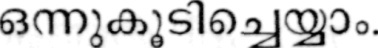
ഒന്നുകൂടിച്ചെയ്യാം.
